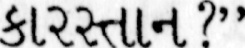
કારસ્તાન?"
